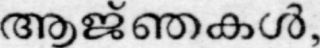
ആജ്ഞകള്‍,
